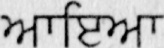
ਆਇਆ
